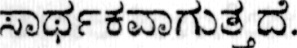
ಸಾರ್ಥಕವಾಗುತ್ತದೆ.
